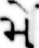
મેં
